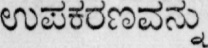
ಉಪಕರಣವನ್ನು
